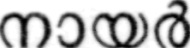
നായര്‍
